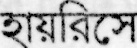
হায়রিসে
